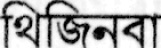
থিজিনবা
